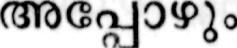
അപ്പോഴും
